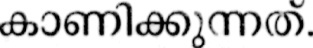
കാണിക്കുന്നത്.
